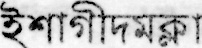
ইশাগীদমক্লা
